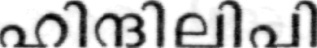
ഹിന്ദിലിപി
